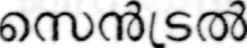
സെന്‍ട്രല്‍
